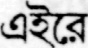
এইরে
